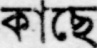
কাছে
